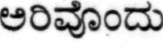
ಅರಿವೊಂದು
